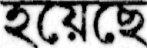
হয়েছে
